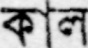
কাল
